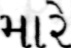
મારે
